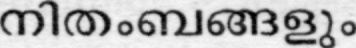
നിതംബങ്ങളും
